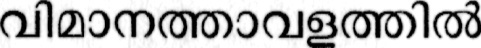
വിമാനത്താവളത്തില്‍
